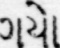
ગયો
